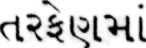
તરફેણમાં
